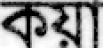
কয়া
